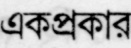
একপ্রকার
